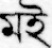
মই
